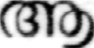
ആ
